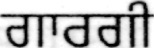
ਗਾਰਗੀ
